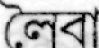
লৈবা
